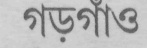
গড়গাঁও
